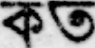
কত
